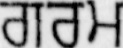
ਗਰਮ
